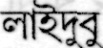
লাইদুবু
